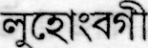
লুহোংবগী
